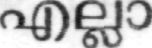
എല്ലാ
